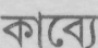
কাব্যে
